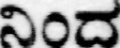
ನಿಂದ
